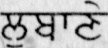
ਲੁਬਾਣੇ
